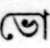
ভো
